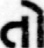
તો
